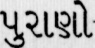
પુરાણો
